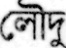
লৌদু
